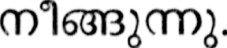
നീങ്ങുന്നു.
